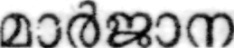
മാര്‍ജാന
